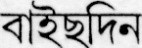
বাইছদিন
